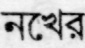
নখের
